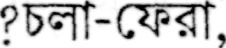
?চলা-ফেরা,
